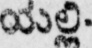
ಯಲ್ಲಿ.
